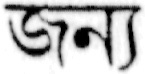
জন্য
